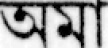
অমা
